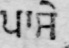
ਪਾਸੇ
